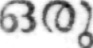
ഒരു
